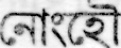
নোংহৌ
